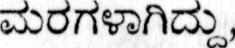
ಮರಗಳಾಗಿದ್ದು,
